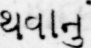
થવાનું
